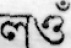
লওঁ
